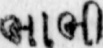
ભાભી
